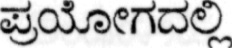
ಪ್ರಯೋಗದಲ್ಲಿ
